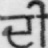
ਦੀ
